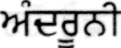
ਅੰਦਰੂਨੀ
